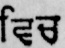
ਵਿਚ
